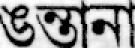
ঙন্তানা
